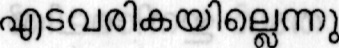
എടവരികയില്ലെന്നു
